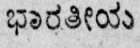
ಭಾರತೀಯ
